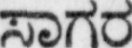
ಸಾಗರ
